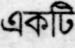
একটি
